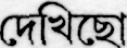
দেখিছো
